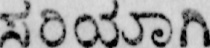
ಸರಿಯಾಗಿ
